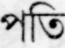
পতি
